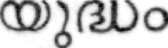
യുദ്ധം
